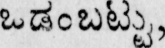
ಒಡಂಬಟ್ಟು,
